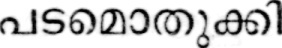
പടമൊതുക്കി
